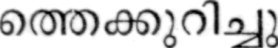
ത്തെക്കുറിച്ചു
